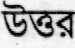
উত্তর
